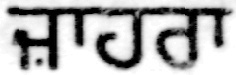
ਜ਼ਾਹਰਾ
